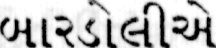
બારડોલીએ
